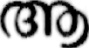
ആ
